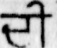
ਦੀ
